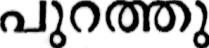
പുറത്തു
